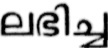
ലഭിച്ച
